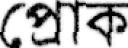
প্রোক
